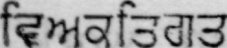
ਵਿਅਕਤਿਗਤ
